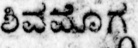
ಶಿವಮೊಗ್ಗ
